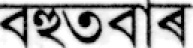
বহুতবাৰ
